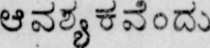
ಆವಶ್ಯಕವೆಂದು
